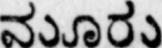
ಮೂರು
